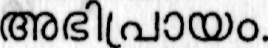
അഭിപ്രായം.
